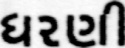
ધરણી
